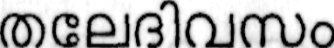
തലേദിവസം
